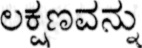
ಲಕ್ಷಣವನ್ನು
